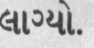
લાગ્યો.
